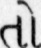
તો
